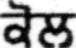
ਕੋਲ
